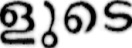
ളുടെ
